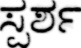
ಸ್ಪರ್ಶ
